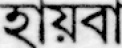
হায়বা
